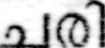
ചരി
